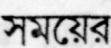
সময়ের
